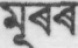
মূৰৰ
